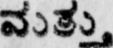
ಮತ್ತು
